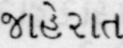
જાહેરાત
